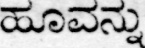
ಹೂವನ್ನು
